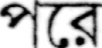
পরে
